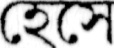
হেসে
